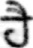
ਹੈ
